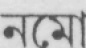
নমো
